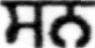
ਸਨ
